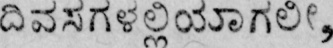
ದಿವಸಗಳಲ್ಲಿಯಾಗಲೀ,
